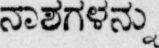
ನಾಶಗಳನ್ನು
